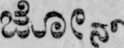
ಜೋನ್
